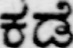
ಕಡೆ
